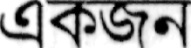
একজন
